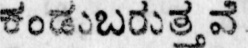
ಕಂಡುಬರುತ್ತವೆ.
